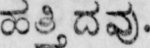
ಹತ್ತಿದವು.
